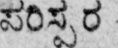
ಪರಿಸ್ಪರ
